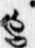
હું
